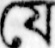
যে
